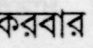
করবার
